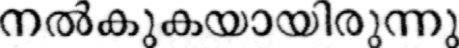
നല്‍കുകയായിരുന്നു
